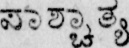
ಪಾಶ್ಚಾತ್ಯ
